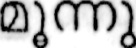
മൂന്നു
